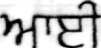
ਆਈ
